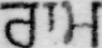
ਰਾਮ
